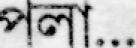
পলা...
